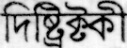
দিষ্ট্রিক্টকী
